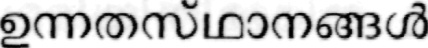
ഉന്നതസ്ഥാനങ്ങള്‍
